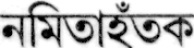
নমিতাহঁতক
